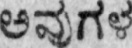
ಅವುಗಳ
